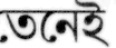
তেনেই
